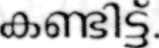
കണ്ടിട്ട്.
